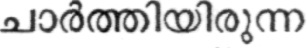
ചാര്‍ത്തിയിരുന്ന
